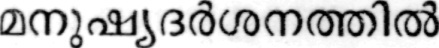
മനുഷ്യദര്‍ശനത്തില്‍
